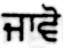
ਜਾਵੋ
